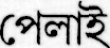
পেলাই
